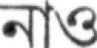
নাও
